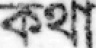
কথা
